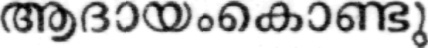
ആദായംകൊണ്ടു
